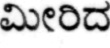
ಮೀರಿದ
